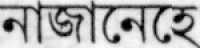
নাজানেহে
